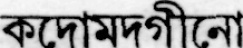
কদোমদগীনো
